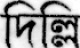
দিল্লি
